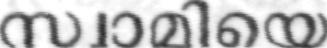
സ്വാമിയെ
